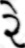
રે
